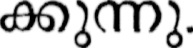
ക്കുന്നു.
